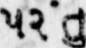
પરંતુ
